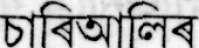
চাৰিআলিৰ
